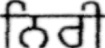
ਨਿਰੀ
